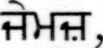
ਜੇਮਜ਼,
